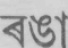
ৰঙা
